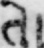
તો
